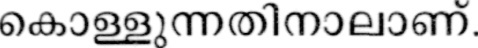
കൊള്ളുന്നതിനാലാണ്.
